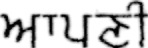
ਆਪਣੀ
